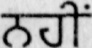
ਨਹੀਂ
